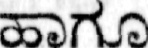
ಹಾಗೂ
